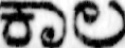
ಕಾಲ
